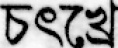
চৎখ্রে
